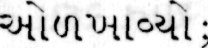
ઓળખાવ્યો;
